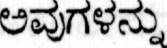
ಅವುಗಳನ್ನು
